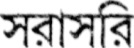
সরাসরি
